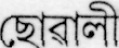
ছোৱালী
